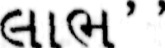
લાભ"
